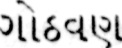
ગોઠવણ
